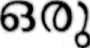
ഒരു
